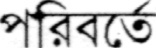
পরিবর্তে
